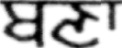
ਬਣਾ
